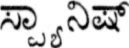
ಸ್ಪ್ಯಾನಿಷ್
